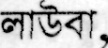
লাউবা,
